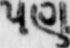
પણ
